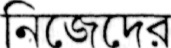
নিজেদের
